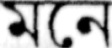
মনে
